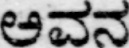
ಅವನ
